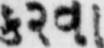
કરવા
